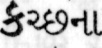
કચ્છના
